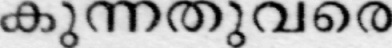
കുന്നതുവരെ
